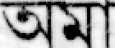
অমা
